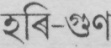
হৰি-গুণ
